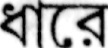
ধারে
